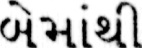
બેમાંથી
